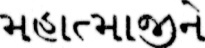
મહાત્માજીને
